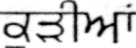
ਕੁੜੀਆਂ
